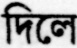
দিলে
